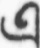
এ
